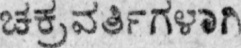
ಚಕ್ರವರ್ತಿಗಳಾಗಿ
